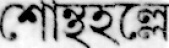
শোন্থহল্লে
